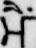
ਮੈਂ
